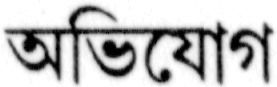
অভিযোগ
